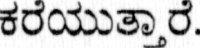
ಕರೆಯುತ್ತಾರೆ.
